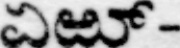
ಏಱ್-
